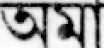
অমা
